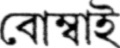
বোম্বাই
